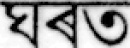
ঘৰত
